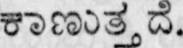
ಕಾಣುತ್ತದೆ.
